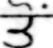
ਤੋਂ
